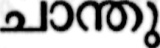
ചാന്തു
